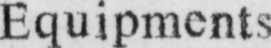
Equipments
